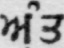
ਅੰਤ
